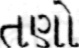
તણો
